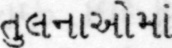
તુલનાઓમાં
